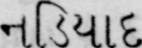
નડિયાદ
